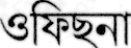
ওফিছনা
